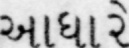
આધારે
